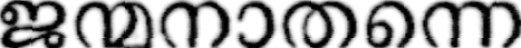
ജന്മനാതന്നെ
